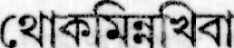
থোকমিন্নখিবা
